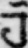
ਹੋ
